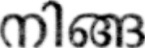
നിങ്ങ
